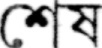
শেষ
